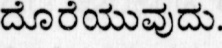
ದೊರೆಯುವುದು.
